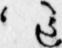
'હે
